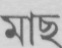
মাছ
